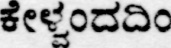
ಕೇಳ್ವಂದದಿಂ
